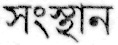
সংস্থান
